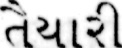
તૈયારી
